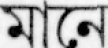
মানে
